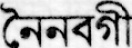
নৈনবগী
